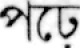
পঢ়ে
